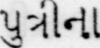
પુત્રીના
